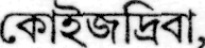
কোইজদ্রিবা,
